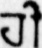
ਹੀ
